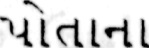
પોતાના
